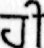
ਹੀ
